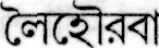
লৈহৌরবা
